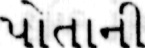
પોતાની
